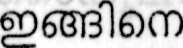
ഇങ്ങിനെ
